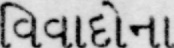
વિવાદોના
